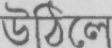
উঠিলে
